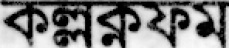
কল্লক্নফম
